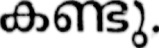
കണ്ടു.
